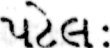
પટેલ:
